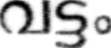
വട്ടം
